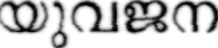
യുവജന
